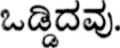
ಒಡ್ಡಿದವು.
